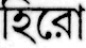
হিরো
